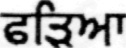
ਫੜਿਆ
